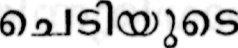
ചെടിയുടെ
